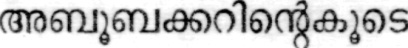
അബൂബക്കറിന്റെകൂടെ
